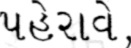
પહેરાવે,
